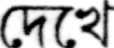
দেখে
